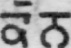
ਕੋਨ
